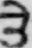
ਤੇ
